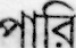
পারি
